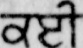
ਕਈ
